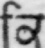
ਕਿ
